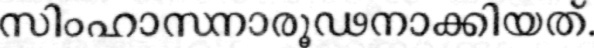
സിംഹാസനാരൂഢനാക്കിയത്.
